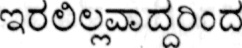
ಇರಲಿಲ್ಲವಾದ್ದರಿಂದ
